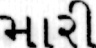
મારી
